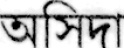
অসিদা
